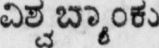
ವಿಶ್ವಬ್ಯಾಂಕು
